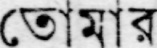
তোমার
